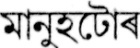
মানুহটোৰ
